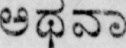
ಅಥವಾ
